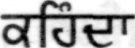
ਕਹਿੰਦਾ
